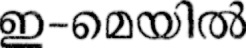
ഇ-മെയില്‍
